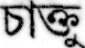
চাক্তু
